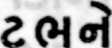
ટભને
